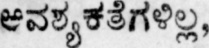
ಅವಶ್ಯಕತೆಗಳಿಲ್ಲ,
